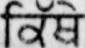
ਕਿੱਥੇ
